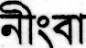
নীংবা
